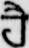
ਹੈ
